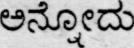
ಅನ್ನೋದು
